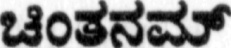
ಚಿಂತನಮ್
